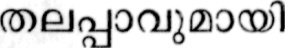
തലപ്പാവുമായി
